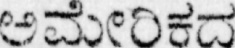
ಅಮೇರಿಕದ
